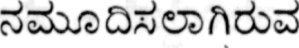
ನಮೂದಿಸಲಾಗಿರುವ
